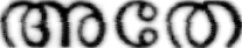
അതേ
